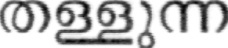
തള്ളുന്ന
